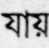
যায়
